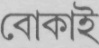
বোকাই
